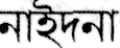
নাইদনা
